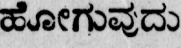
ಹೋಗುವುದು
